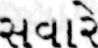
સવારે
